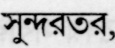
সুন্দরতর,
